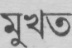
মুখত
